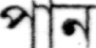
পান
